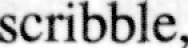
scribble,
